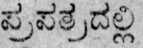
ಪ್ರಪತ್ರದಲ್ಲಿ
